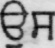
ਉਸ
